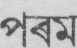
পৰম
